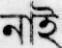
নাই
